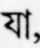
যা,
